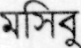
মসিবু
